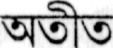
অতীত
